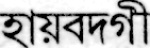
হায়বদগী
